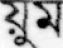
য়ুম
